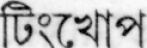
টিংখোপ
